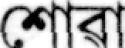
শোৱা
